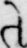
તે
